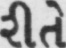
રીતે
